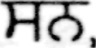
ਸਨ,
